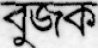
বুজক
